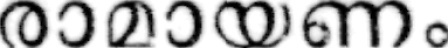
രാമായണം
